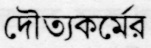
দৌত্যকর্মের
